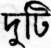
দুটি
